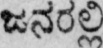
ಜನರಲ್ಲಿ
